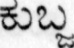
ಕುಬ್ಜ
